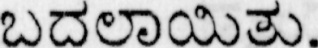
ಬದಲಾಯಿತು.
